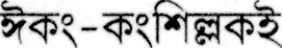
ঈকং-কংশিল্লকই
